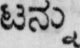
ಟನ್ನು
